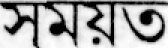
সময়ত
